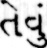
તેવું
